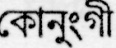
কোনুংগী
